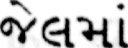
જેલમાં
